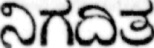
ನಿಗದಿತ
